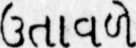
ઉતાવળે
